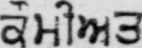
ਕੌਮੀਅਤ
